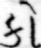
કો
